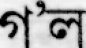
গ'ল
